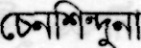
চেনশিন্দুনা
